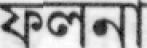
ফলনা
